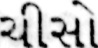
ચીસો
